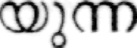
യുന്ന
